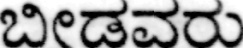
ಬೀಡವರು
